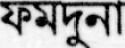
ফমদুনা
